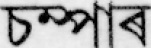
চম্পাৰ
